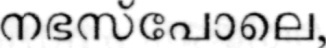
നഭസ്പോലെ,
